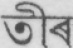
তীৰ
